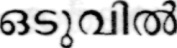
ഒടുവില്‍
